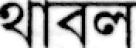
থাবল
